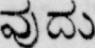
ವುದು
